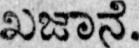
ಖಜಾನೆ.
